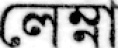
লেম্না
